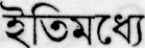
ইতিমধ্যে
